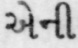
એની
